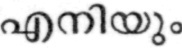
എനിയും
